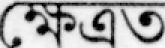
ক্ষেত্রত
